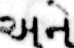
અને
